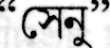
“সেনু”
